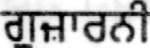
ਗੁਜ਼ਾਰਨੀ
